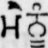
ਮੈਨੂੰ
